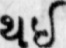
થઈ
